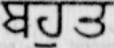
ਬਹੁਤ
